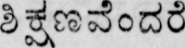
ಶಿಕ್ಷಣವೆಂದರೆ
